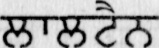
ਲਾਲਟੈਨ
